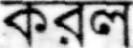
করল
